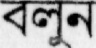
বলুন
